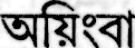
অয়িংবা
